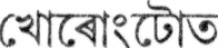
খোৰোংটোত
